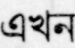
এখন
